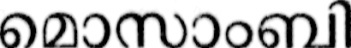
മൊസാംബി
